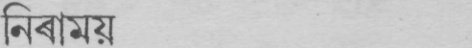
নিৰাময়
